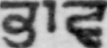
ਭਾਵ
